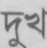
দুখ
